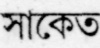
সাকেত
